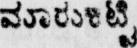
ಮಾರುಕಟ್ಟೆ
